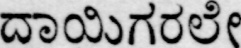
ದಾಯಿಗರಲೇ
